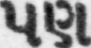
પણ
